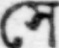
সে
